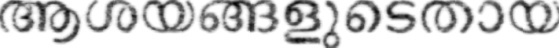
ആശയങ്ങളുടെതായ
